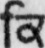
ਕਿ
